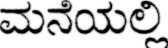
ಮನೆಯಲ್ಲಿ
